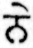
ਨੇ
